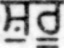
ਸ਼ੁਰੂ
